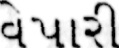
વેપારી
